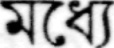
মধ্যে
